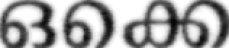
ഒക്കെ
